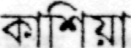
কাশিয়া
